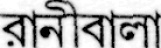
রানীবালা
